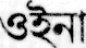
ওইনা
